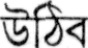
উঠিব
